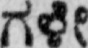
ಗಳೇ
